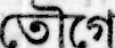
তৌগে
